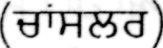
(ਚਾਂਸਲਰ)
